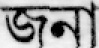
জনা
